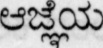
ಆಜ್ಞೆಯ
